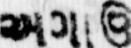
અગાઉ
